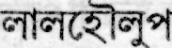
লালহৌলুপ
